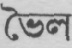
ভৈল
